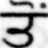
ਤੋਂ
